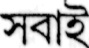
সবাই
